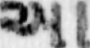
આ
